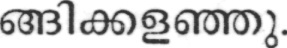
ങ്ങിക്കളഞ്ഞു.
